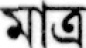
মাত্র
